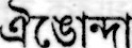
ঐঙোন্দা
